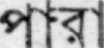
পারা
